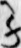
કે
